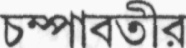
চম্পাবতীর
